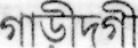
গাড়ীদগী
